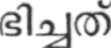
ഭിച്ചത്
